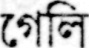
গেলি
